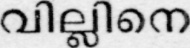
വില്ലിനെ
